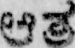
ಆತ
